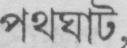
পথঘাট,
